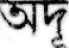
অদূ
